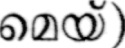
മെയ്)
